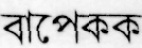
বাপেকক
